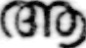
ആ
